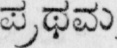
ಪ್ರಥಮ
